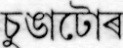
চুঙাটোৰ
